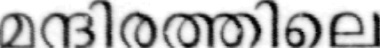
മന്ദിരത്തിലെ
